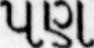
પણ
